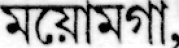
ময়োমগা,
